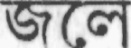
জলে
